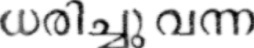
ധരിച്ചുവന്ന
